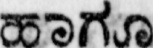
ಹಾಗೂ
